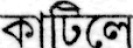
কাটিলে
